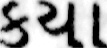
કયા
